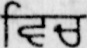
ਵਿਚ
